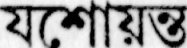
যশোয়ন্ত
